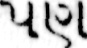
પણ
